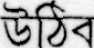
উঠিব
